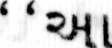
"આ
